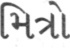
મિત્રો
